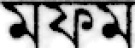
মফম
